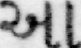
આ
